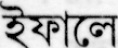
ইফালে
